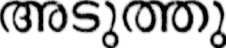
അടുത്തു
